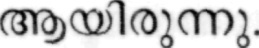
ആയിരുന്നു.
